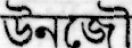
উনজৌ
